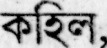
কহিল,
